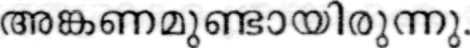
അങ്കണമുണ്ടായിരുന്നു.
